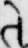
તે
